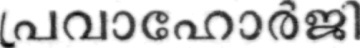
പ്രവാഹോര്‍ജി
